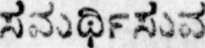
ಸಮರ್ಥಿಸುವ
